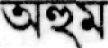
অহুম
